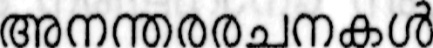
അനന്തരരചനകള്‍
